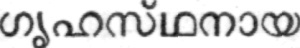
ഗൃഹസ്ഥനായ
